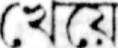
খেয়ে
